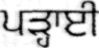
ਪੜ੍ਹਾਈ
